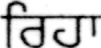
ਰਿਹਾ
